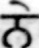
ਨੇ
